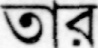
তার
